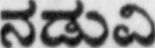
ನಡುವಿ
